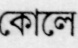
কোলে
